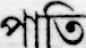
পাতি
